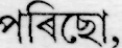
পৰিছো,
